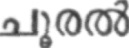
ചൂരല്‍
